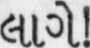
લાગે!
